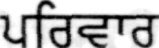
ਪਰਿਵਾਰ
